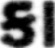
કા
